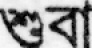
শুবা
